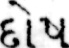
દોષ
